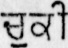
ਚੁਕੀ
